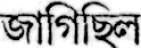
জাগিছিল
